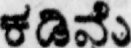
ಕಡಿಮೆ
